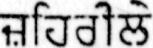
ਜ਼ਹਿਰੀਲੇ
